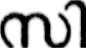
സി
